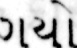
ગયો
